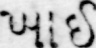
ખાઈ
